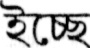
ইচ্ছে
